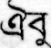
ঐবু
